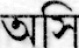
অসি
